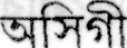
অসিগী
